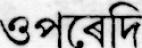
ওপৰেদি
